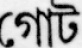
গোট
